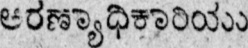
ಅರಣ್ಯಾಧಿಕಾರಿಯು
